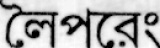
লৈপরেং
